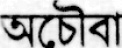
অচৌবা
